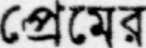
প্রেমের
